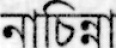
নাচিন্না
